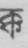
ক্ক
